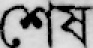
শেষ
